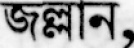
জল্লান,
